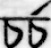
চর্চ
